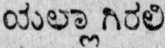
ಯಲ್ಲಾಗಿರಲಿ
